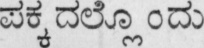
ಪಕ್ಕದಲ್ಲೊಂದು
